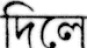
দিলে
